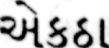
એકઠા
